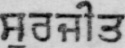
ਸੁਰਜੀਤ
